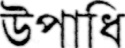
উপাধি
